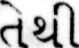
તેથી
